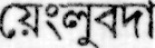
য়েংলুবদা
